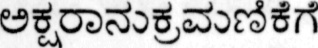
ಅಕ್ಷರಾನುಕ್ರಮಣಿಕೆಗೆ
